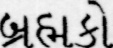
બ્રહ્મકો
